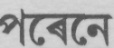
পৰেনে
